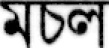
মচল
